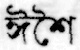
ঈশৈ
